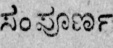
ಸಂಪೂರ್ಣ
